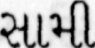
સામી
